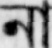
না
